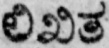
ಲಿಖಿತ
